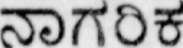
ನಾಗರಿಕ
